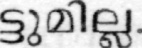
ട്ടുമില്ല.
